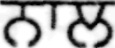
ਨਾਲ
